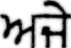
ਅਜੇ
